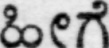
ಹೀಗೆ
